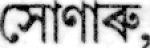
সোণাৰু,
